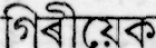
গিৰীয়েক
